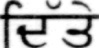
ਦਿੱਤੇ
